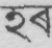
হৰ
